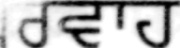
ਰਵਾਹ
